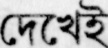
দেখেই
